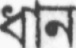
ধান
